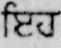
ਇਹ
